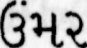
ઉંમર
